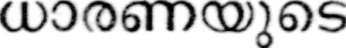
ധാരണയുടെ
